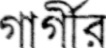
গার্গীর
